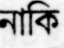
নাকি
